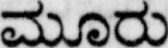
ಮೂರು
